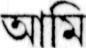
আমি
